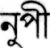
নুপী
